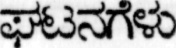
ಘಟನೆಗಳು
